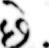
છે.
